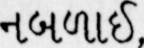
નબળાઈ,
